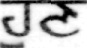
ਹੁਣ
